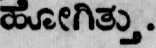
ಹೋಗಿತ್ತು.
